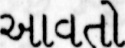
આવતો
